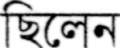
ছিলেন
